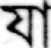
যা
